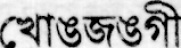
খোঙজঙগী
